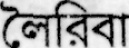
লৈরিবা
